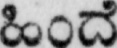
ಹಿಂದೆ
